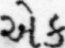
એક
